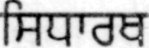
ਸਿਧਾਰਥ
